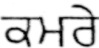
ਕਮਰੇ
